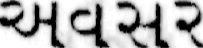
અવસર
